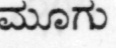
ಮೂಗು
